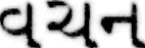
વચન
